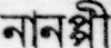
নানপ্পী
